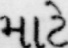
માટે
